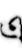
এ
